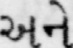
અને
